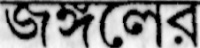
জঙ্গলের
